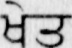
ਖੇਤ
